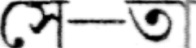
সে–তা
